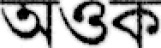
অওক
